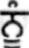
ਨੂੰ
